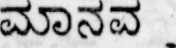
ಮಾನವ.
